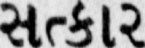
સ્તકાર
